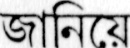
জানিয়ে
